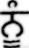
ਨੂੰ
